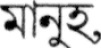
মানুহ,
